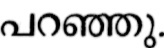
പറഞ്ഞു.
